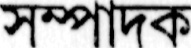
সম্পাদক
